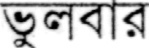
ভুলবার
